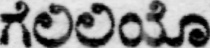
ಗೆಲಿಲಿಯೊ
